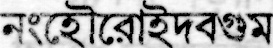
নংহৌরোইদবগুম
